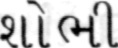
શોભી
